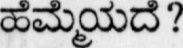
ಹೆಮ್ಮೆಯದೆ?
